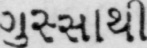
ગુસ્સાથી
